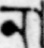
না
